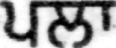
ਪਲਾ
